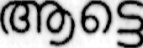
ആട്ടെ
